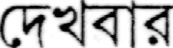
দেখবার
